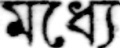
মধ্যে
